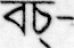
বচ্‌-
